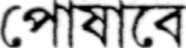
পোষাবে
